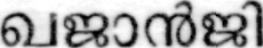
ഖജാന്‍ജി
